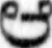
ಆ
